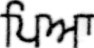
ਪਿਆ
